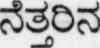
ನೆತ್ತರಿನ
